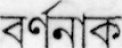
বর্ণনাক
